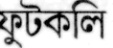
ফুটকলি
